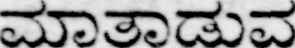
ಮಾತಾಡುವ
